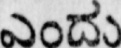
ಎಂದು
